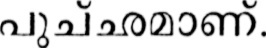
പുച്ഛമാണ്.
